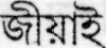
জীয়াই
